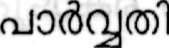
പാര്‍വ്വതി
